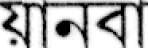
য়ানবা
